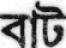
বাট
